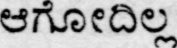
ಆಗೋದಿಲ್ಲ
